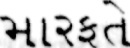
મારફતે
